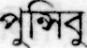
পুন্সিবু
